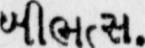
બીભત્સ.
